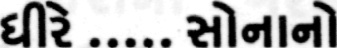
ધીરે.....સોનાનો
